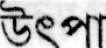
উৎপা
